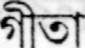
গীতা
